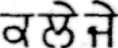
ਕਲੇਜੇ
